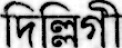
দিল্লিগী
